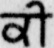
ਕੀ
